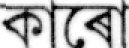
কাৰো
